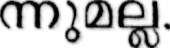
ന്നുമല്ല.
